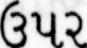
ઉપર
